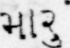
મારું
